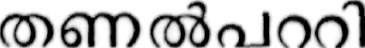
തണല്‍പററി
